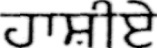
ਹਾਸ਼ੀਏ
